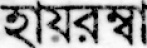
হাযরম্বা
